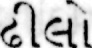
ઢીલો
